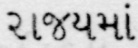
રાજ્યમાં
